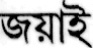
জয়াই
